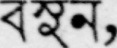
বসুন,
